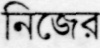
নিজের
